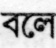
বলে
